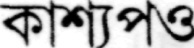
কাশ্যপও
